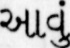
આવું
